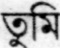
তুমি
